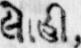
લોહી,
